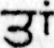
ਤਾਂ
